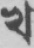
খ
